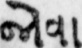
જોવા
